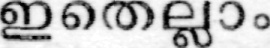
ഇതെല്ലാം
